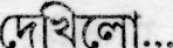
দেখিলো...
